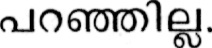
പറഞ്ഞില്ല.
